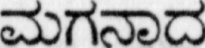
ಮಗನಾದ
